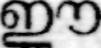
ഈ
